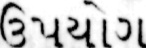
ઉપયોગ
